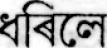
ধৰিলে
